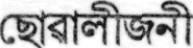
ছোৱালীজনী
